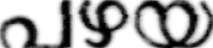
പഴയ
